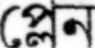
প্লেন
